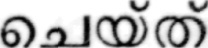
ചെയ്ത്
